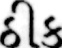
ઠીક
